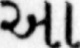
આ
